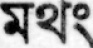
মথং
